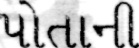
પોતાની
